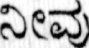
ನೀವು
